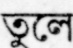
তুলে
